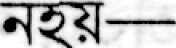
নহয়-
